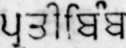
ਪ੍ਰਤੀਬਿੰਬ
